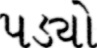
પડ્યો
